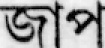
জাপ
